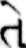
તે
